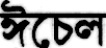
ঈচেল
